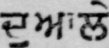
ਦੁਆਲੇ
